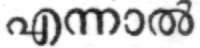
എന്നാല്‍
